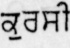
ਕੁਰਸੀ
